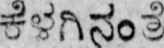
ಕೆಳಗಿನಂತೆ
